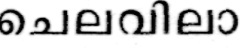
ചെലവിലാ
